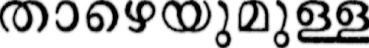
താഴെയുമുള്ള
